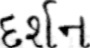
દર્શન
